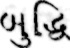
બુદ્ધિ
